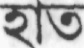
হাত
